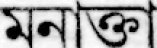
মনাক্তা
